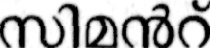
സിമന്റ്
